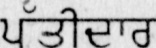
ਪੱਤੀਦਾਰ
